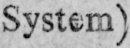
System)
